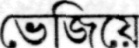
ভেজিয়ে
